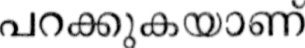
പറക്കുകയാണ്
